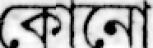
কোনো
